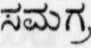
ಸಮಗ್ರ
